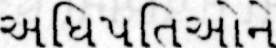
અધિપતિઓને
